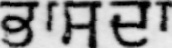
ਭਾਸਦਾ
